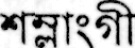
শম্লাংগী
